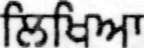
ਲਿਖਿਆ
